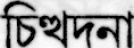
চিত্থদনা
